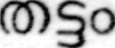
തട്ടം
